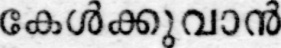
കേള്‍ക്കുവാന്‍
